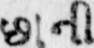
છાની
